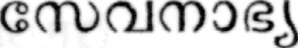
സേവനാഭ്യ
